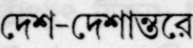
দেশ-দেশান্তরে
